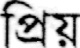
প্রিয়
